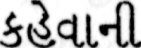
કહેવાની
